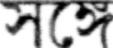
সঙ্গে
